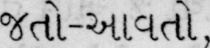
જતો-આવતો,
